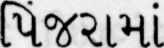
પિંજરામાં
